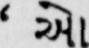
'ઓ
